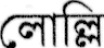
লোল্লি
